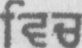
ਵਿਚ
